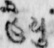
હૈયું
